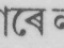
গৰে
